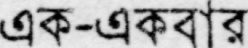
এক-একবার
